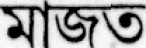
মাজত
